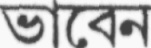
ভাবেন
